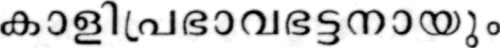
കാളിപ്രഭാവഭട്ടനായും
